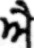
ਐ
